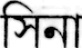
সিনা
